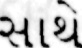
સાથે
